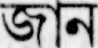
জান
